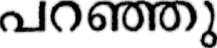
പറഞ്ഞു
